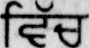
ਵਿੱਚ
